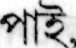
পাই,
